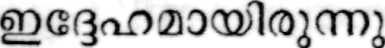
ഇദ്ദേഹമായിരുന്നു
